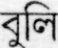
বুলি
